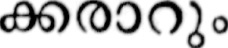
ക്കരാറും
